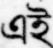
এই
